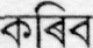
কৰিব
